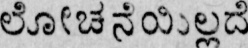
ಲೋಚನೆಯಿಲ್ಲದೆ
